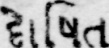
દોષિત
